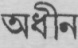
অধীন
